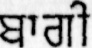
ਬਾਗੀ
